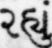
રહ્યું
